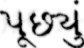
પૂછ્યું
